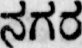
ನಗರ
